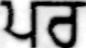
ਪਰ
